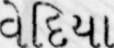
વેદિયા
